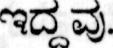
ಇದ್ದವು.
